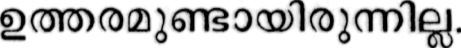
ഉത്തരമുണ്ടായിരുന്നില്ല.
